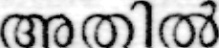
അതില്‍
